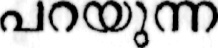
പറയുന്ന
